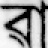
ৱা
